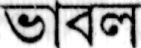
ভাবল
